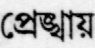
প্রেঙ্খায়
